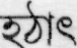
হঠাৎ
